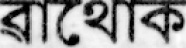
ৱাথোক
